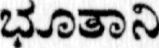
ಭೂತಾನಿ
